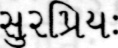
સુરપ્રિયઃ
